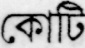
কোটি
